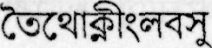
তৈথোক্নীংলবসু
